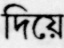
দিয়ে
